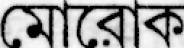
মোরোক
